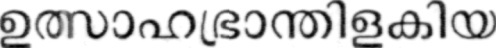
ഉത്സാഹഭ്രാന്തിളകിയ
